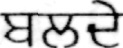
ਬਲਦੇ
